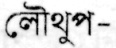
লৌথুপ-
